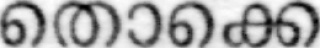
തൊക്കെ
